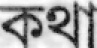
কথা
